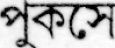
পুকসে
